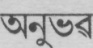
অনুভৱ
